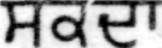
ਸਕਦਾ
